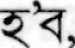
হ'ব,
